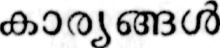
കാര്യങ്ങള്‍
